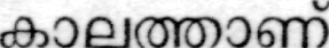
കാലത്താണ്
